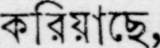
করিয়াছে,
